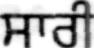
ਸਾਰੀ
